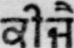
ਕੀਜੈ
